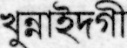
খুন্নাইদগী
